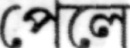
পেলে
